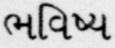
ભવિષ્ય
